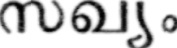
സഖ്യം
